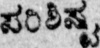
ಪರಿಶಿಷ್ಟ
